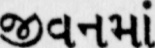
જીવનમાં
